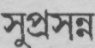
সুপ্ৰসন্ন
